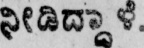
ನೀಡಿದ್ದಾಳೆ.
